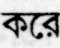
করে
